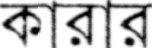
কারার
